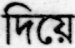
দিয়ে
